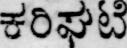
ಕರಿಘಟೆ
